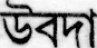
উবদা
